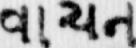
વાચન
